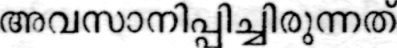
അവസാനിപ്പിച്ചിരുന്നത്
